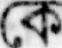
কে
